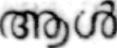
ആള്‍
